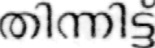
തിന്നിട്ട്
